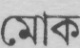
মোক
